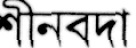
শীনবদা
